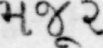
મજૂર
